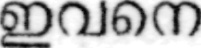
ഇവനെ
